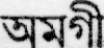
অমগী
